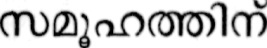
സമൂഹത്തിന്
